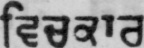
ਵਿਚਕਾਰ
